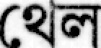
থেল
